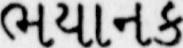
ભયાનક
